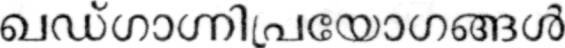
ഖഡ്ഗാഗ്നിപ്രയോഗങ്ങള്‍
